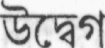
উদ্বেগ
